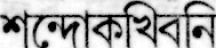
শন্দোকখিবনি
